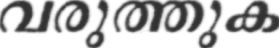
വരുത്തുക
